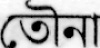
তৌনা
